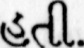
હતી.
